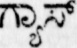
ಗ್ಯಾಸ್
